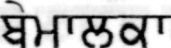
ਬੇਮਾਲਕਾ
